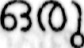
ഒരു
